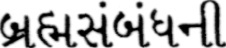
બ્રહ્મસંબંધની
